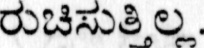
ರುಚಿಸುತ್ತಿಲ್ಲ.
